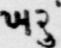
ખરું
